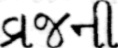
વ્રજની
